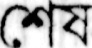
শেষ
